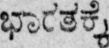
ಭಾರತಕ್ಕೆ
